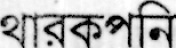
থারকপনি
